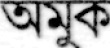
অমুক
